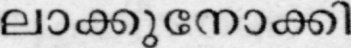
ലാക്കുനോക്കി
